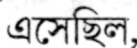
এসেছিল,
